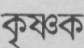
কৃষ্ণক
